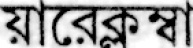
য়ারেক্লম্বা
